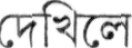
দেখিলে
